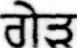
ਗੇੜ
